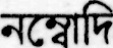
নন্বোদি
